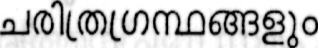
ചരിത്രഗ്രന്ഥങ്ങളും
